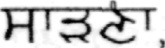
ਸਾੜਣਾ,
